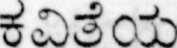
ಕವಿತೆಯ
